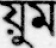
য়ুম
